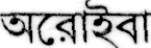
অরোইবা
